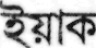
ইয়াক
